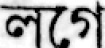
লগে
